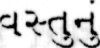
વસ્તુનું
